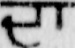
ਦਾ
